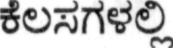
ಕೆಲಸಗಳಲ್ಲಿ
